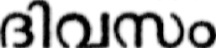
ദിവസം
